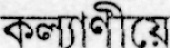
কল্যাণীয়ে
